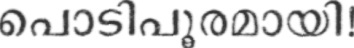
പൊടിപൂരമായി!
